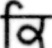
ਕਿ
